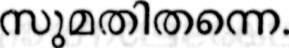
സുമതിതന്നെ.
